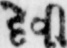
દેવી
